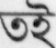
তই
